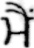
ਮੈਂ
